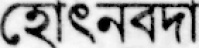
হোৎনবদা
